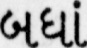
બધાં
